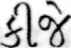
કીજે
